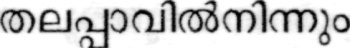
തലപ്പാവില്‍നിന്നും
